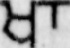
ਖਾ
